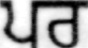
ਪਰ
